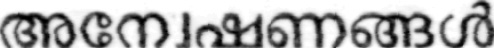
അന്വേഷണങ്ങള്‍
